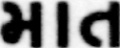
માત
